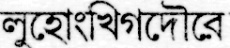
লুহোংখিগদৌরে
